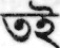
তই
